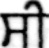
ਸੀ
